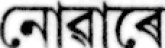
নোৱাৰে
